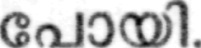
പോയി.
